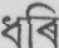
ধৰি
